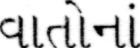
વાતોનાં
